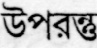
উপরন্তু
